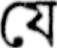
যে
